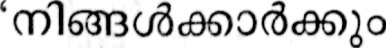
‘നിങ്ങള്‍ക്കാര്‍ക്കും
